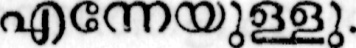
എന്നേയുള്ളു.
